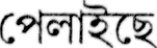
পেলাইছে
